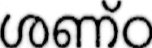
ശണ്ഠ
